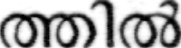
ത്തില്‍
